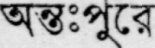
অন্তঃপুরে
